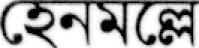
হেনমল্লে
